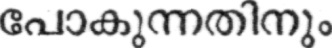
പോകുന്നതിനും
